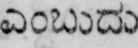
ಎಂಬುದು
